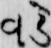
વડે
